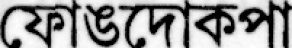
ফোঙদোকপা
